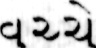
વચ્ચે
